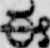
ಈ
